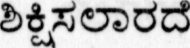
ಶಿಕ್ಷಿಸಲಾರದೆ
